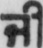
ਜੀ
